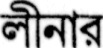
লীনার
